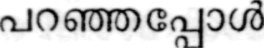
പറഞ്ഞപ്പോള്‍
